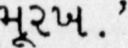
મૂરખ.'
